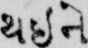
થઈને
